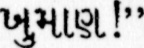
ખુમાણ!"
